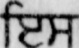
ਇਸ
